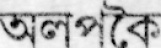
অলপকৈ
